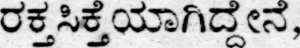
ರಕ್ತಸಿಕ್ತೆಯಾಗಿದ್ದೇನೆ,
